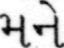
મને
